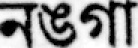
নঙগা
